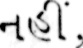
નહીં,
